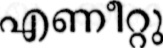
എണീറ്റു
